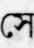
সে
